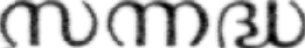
സന്നദ്ധ
